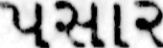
પસાર
